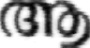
ആ
